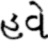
હવે
